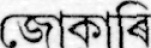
জোকাৰি
